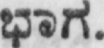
ಭಾಗ.
